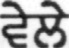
ਵੇਲੇ
